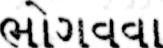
ભોગવવા
